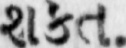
શકત.
